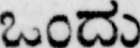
ಒಂದು
